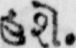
હશે.
